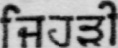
ਜਿਹੜੀ
